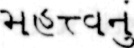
મહત્ત્વનું
